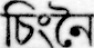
চিংনৈ
